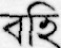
বহি
